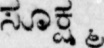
ಸೂಕ್ಷ್ಮ
